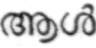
ആള്‍
